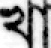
খা
